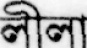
লীলা
